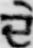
ਦੇ
